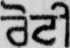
ਰੋਟੀ
